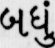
બધું
